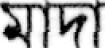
মাদা
